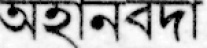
অহানবদা
